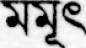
মমূৎ
